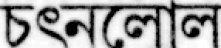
চৎনলোল
